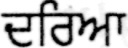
ਦਰਿਆ
